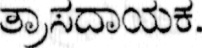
ತ್ರಾಸದಾಯಕ.
